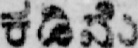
ಕಡಿಮೆ
